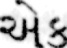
એક
